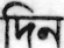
দিন
